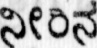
ನೀರಿನ
